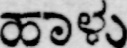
ಹಾಳು
